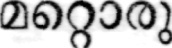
മറ്റൊരു
